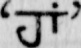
'ਹਾਂ'
